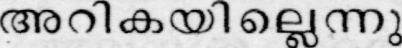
അറികയില്ലെന്നു
